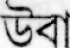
উবা
